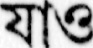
যাও
